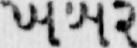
ખબર
